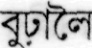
বুঢ়ালৈ
